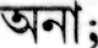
অনা;
